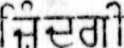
ਜ਼ਿੰਦਗੀ
